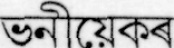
ভনীয়েকৰ
